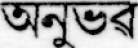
অনুভৱ
